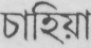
চাহিয়া
